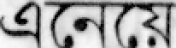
এনেয়ে
